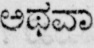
ಅಥವಾ
